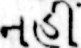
નહીં
